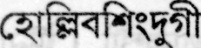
হোল্লিবশিংদুগী
